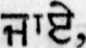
ਜਾਏ,
